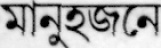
মানুহজনে
